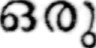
ഒരു
